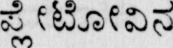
ಪ್ಲೇಟೋವಿನ
